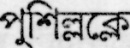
পুশিল্লক্লে
